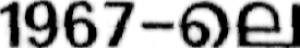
1967-ലെ
